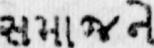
સમાજને
